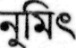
নুমিৎ
